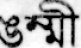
ঙম্মী
